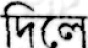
দিলে
